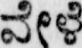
ವೇಳೆ
